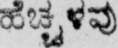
ಹೆಚ್ಚಳವು
